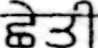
ਛੇਤੀ
